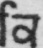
ਕਿ
